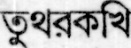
তুথরকখি
